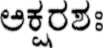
ಅಕ್ಷರಶಃ
